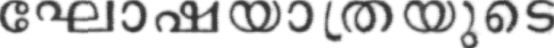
ഘോഷയാത്രയുടെ
